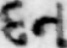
દન
